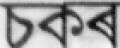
চকৰ
